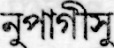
নুপাগীসু
